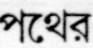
পথের
